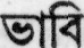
ভাবি
